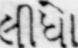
લીધો
